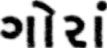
ગોરાં
